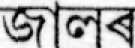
জালৰ
